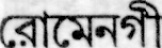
রোমেনগী
